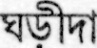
ঘড়ীদা
